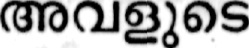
അവളുടെ
